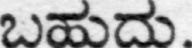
ಬಹುದು.
